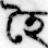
হৈ
